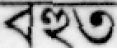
বহুত
